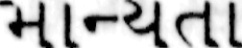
માન્યતા
